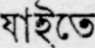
যাইতে
